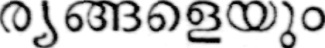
ര്യങ്ങളെയും
